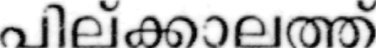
പില്ക്കാലത്ത്
